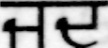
ਜਦ
